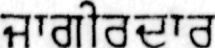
ਜਾਗੀਰਦਾਰ
